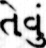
તેવું
